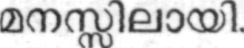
മനസ്സിലായി.
